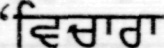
'ਵਿਚਾਰਾ
